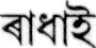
ৰাধাই
